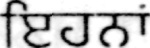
ਇਹਨਾਂ
